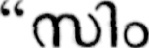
“സിം
